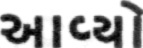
આવ્યો
